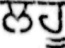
ਲਹੂ
